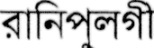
রানিপুলগী
